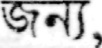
জন্য,
